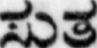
ಸುತ
